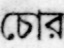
চোর
